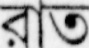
রাত
